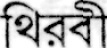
থিরবী
